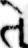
તે
